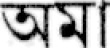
অমা
